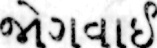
જોગવાઈ
